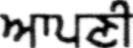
ਆਪਣੀ
